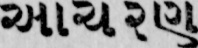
આચરણ
